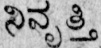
ನಿವೃತ್ತಿ
